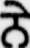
ਨੇ
